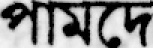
পামদে
